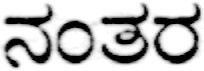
ನಂತರ
